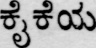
ಕೈಕೆಯ
